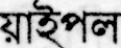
য়াইপল
